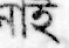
নাই
